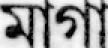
মাগা
